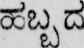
ಹಬ್ಬದ
